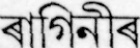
ৰাগিনীৰ
